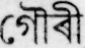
গৌৰী
